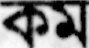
কম
